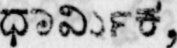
ಧಾರ್ಮಿಕ,
